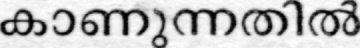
കാണുന്നതില്‍
